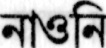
নাওনি
